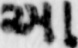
આ
